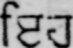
ਇਹ
